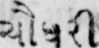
ચૌધરી
